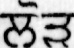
ਲੋੜ
